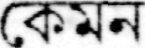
কেমন
